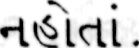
નહોતાં.
